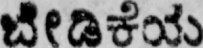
ಬೇಡಿಕೆಯ
